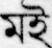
মই
